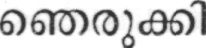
ഞെരുക്കി
